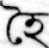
হৈ
